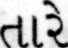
તારે
